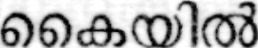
കൈയില്‍
